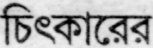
চিৎকারের
